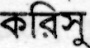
করিসু
